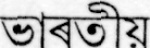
ভাৰতীয়
